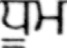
ਧੂਮ
